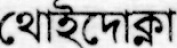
থোইদোক্না
